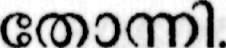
തോന്നി.
